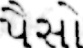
પૈસો
